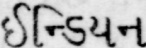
ઈન્ડિયન
